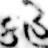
કહે
